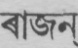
ৰাজন্
